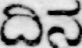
ದಿನ
